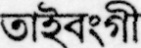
তাইবংগী
